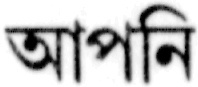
আপনি
